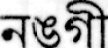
নঙগী
